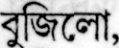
বুজিলো,
